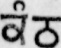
ਕੰਠ
